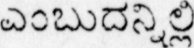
ಎಂಬುದನ್ನಿಲ್ಲಿ
